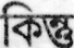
কিন্তু
